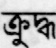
ক্রুদ্ধ
